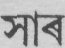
সাৰ
